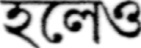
হলেও
